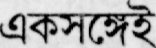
একসঙ্গেই
